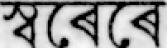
স্বৰেৰে
